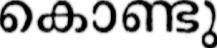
കൊണ്ടു
